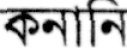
কনানি
